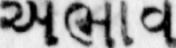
અભાવ
